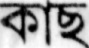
কাছ
